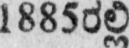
1885ರಲ್ಲಿ
